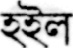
হইল
